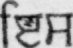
ਇਸ
